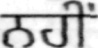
ਨਹੀਂ
